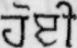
ਹੋਈ
